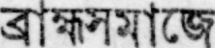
ব্রাহ্মসমাজে
